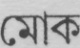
মোক
